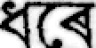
ধৰে
